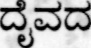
ದೈವದ
